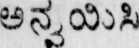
ಅನ್ವಯಿಸಿ
